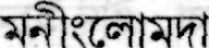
মনীংলোমদা
